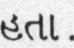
હતા.
